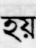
হয়
